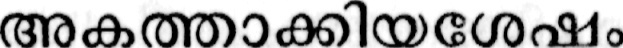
അകത്താക്കിയശേഷം
